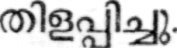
തിളപ്പിച്ചു.
